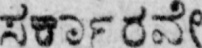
ಸರ್ಕಾರವೇ
